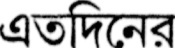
এতদিনের
